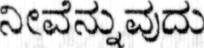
ನೀವೆನ್ನುವುದು
